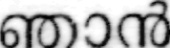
ഞാന്‍
